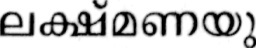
ലക്ഷ്മണയു
